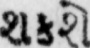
શકશે
